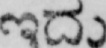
ಇದು
